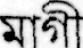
মাগী
